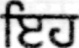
ਇਹ
